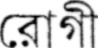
রোগী
